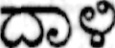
ದಾಳಿ
